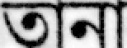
তানা
